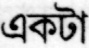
একটা
